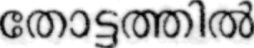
തോട്ടത്തില്‍
